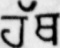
ਹੱਥ
